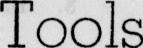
Tools
